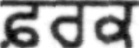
ਫ਼ਰਕ
